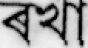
ৰখা
